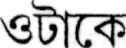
ওটাকে
